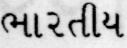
ભારતીય
